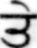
ਤੇ
